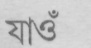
যাওঁ
